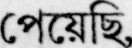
পেয়েছি,
